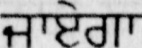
ਜਾਏਗਾ
